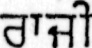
ਰਾਜੀ
